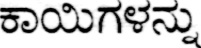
ಕಾಯಿಗಳನ್ನು
